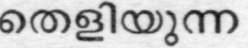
തെളിയുന്ന
